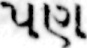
પણ
